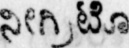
ನೀಗ್ರಿಟೊ
